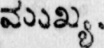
ಮುಖ್ಯ.
